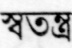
স্বতন্ত্র
